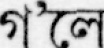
গ'লে
